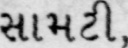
સામટી,
